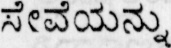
ಸೇವೆಯನ್ನು
